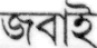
জবাই
